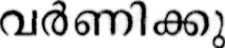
വര്‍ണിക്കു
